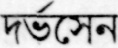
দর্ভসেন
